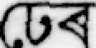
ঢেৰ
